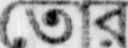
তোর
